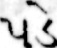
પડે
